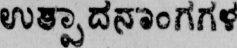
ಉತ್ಪಾದನಾಂಗಗಳ
